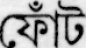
ফোঁট
